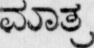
ಮಾತ್ರ
